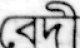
বেদী
